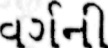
વર્ગની
